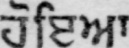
ਹੋਇਆ
